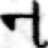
ન
